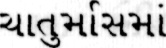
ચાતુર્માસમાં
